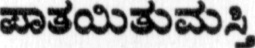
ಪಾತಯಿತುಮಸ್ತಿ
